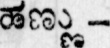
ಹಣ್ಣು-
